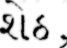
શેઠ,
